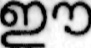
ഈ
